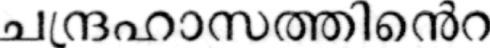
ചന്ദ്രഹാസത്തിന്റെ
